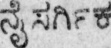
ನೈಸರ್ಗಿಕ
